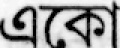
একো
